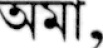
অমা,
